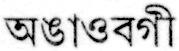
অঙাওবগী
